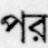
পর
